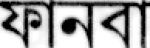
ফানবা
